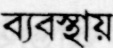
ব্যবস্থায়
